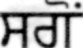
ਸਗੋਂ
